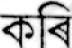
কৰি
